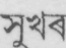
সুখৰ
